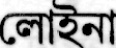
লোইনা
